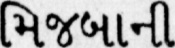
મિજબાની
